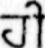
ਹੀ
